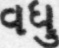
વધુ
